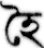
হৈ
